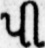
પી
